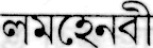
লমহেনবী
